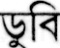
ডুবি
